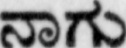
ನಾಗು
